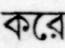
করে
